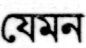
যেমন
